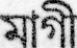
মাগী
